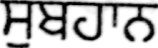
ਸੁਬਹਾਨ
